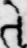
તે
